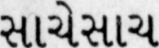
સાચેસાચ
